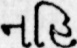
નહિ
